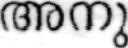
അനു
